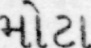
મોટા
